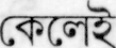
কেলেই
